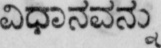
ವಿಧಾನವನ್ನು
